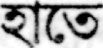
হাতে
